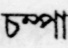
চম্পা
